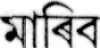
মাৰিব
